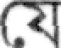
যে
